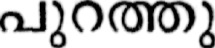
പുറത്തു
